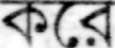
করে
